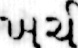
ખર્ચ
